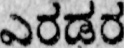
ಎರಡರ
